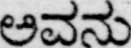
ಅವನು
